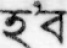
হ'ব
